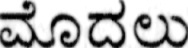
ಮೊದಲು
